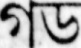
গড
